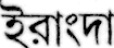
ইরাংদা
